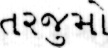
તરજુમો
